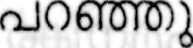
പറഞ്ഞു
